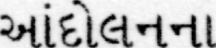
આંદોલનના
